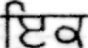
ਇਕ
